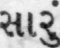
સારું
